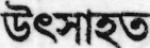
উৎসাহত
